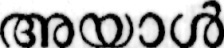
അയാള്‍
